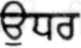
ਉਧਰ
